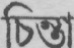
চিন্তা
